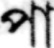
পা
